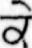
ਕੇ
